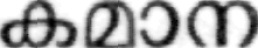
കമാന
